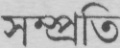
সম্প্রতি
